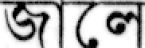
জালে
